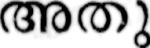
അതു
